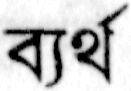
ব্যর্থ
